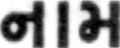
નામ
